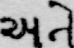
અને
